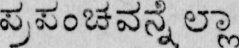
ಪ್ರಪಂಚವನ್ನೆಲ್ಲಾ
